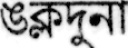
ঙক্লদুনা
